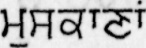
ਮੁਸਕਾਣਾਂ
